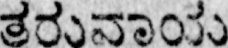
ತರುವಾಯ
